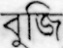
বুজি
